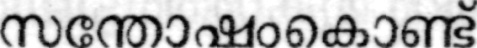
സന്തോഷംകൊണ്ട്
